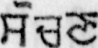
ਸੋਚਣ
